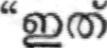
“ഇത്
